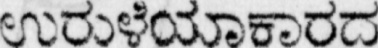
ಉರುಳೆಯಾಕಾರದ
